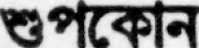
শুপকোন
